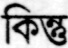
কিন্তু
